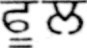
ਫੂਲ
